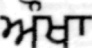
ਔਖਾ
